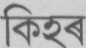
কিহৰ
